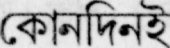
কোনদিনই
